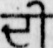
ਦੀ
